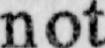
not
